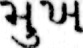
મુખ
